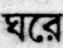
ঘরে
